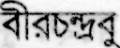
বীরচন্দ্রবু
